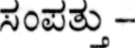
ಸಂಪತ್ತು-
